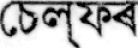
চেলফৰ
